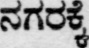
ನಗರಕ್ಕೆ
